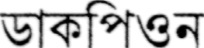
ডাকপিওন
